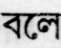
বলে
